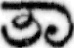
ತಾ
